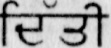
ਦਿੱਤੀ
